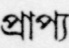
প্রাপ্য
